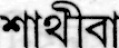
শাথীবা
